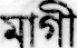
মাগী
